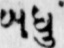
બધું
